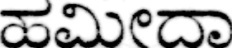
ಹಮೀದಾ
